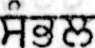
ਸੰਭਲ
